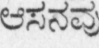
ಆಸನವು
